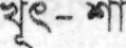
খূৎ-শা
